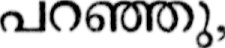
പറഞ്ഞു,
